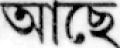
আছে
